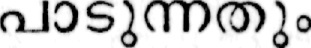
പാടുന്നതും
